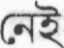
নেই
